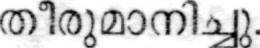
തീരുമാനിച്ചു.
